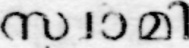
സ്വാമി
